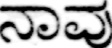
ನಾವು
